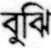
বুঝি
